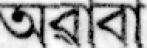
অৱাবা
